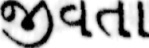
જીવતા
